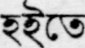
হইতে
